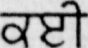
ਕਈ
